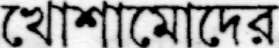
খোশামোদের
